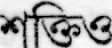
শক্তিও
